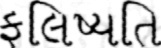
ફલિષ્યતિ
